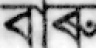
বাৰু
